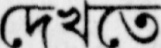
দেখতে
